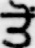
ਤੋਂ
